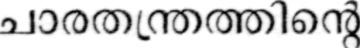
ചാരതന്ത്രത്തിന്റെ
